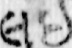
લઈ
